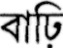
বাঢ়ি
